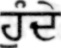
ਹੁੰਦੇ
